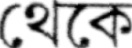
থেকে
